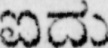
ಐದು
